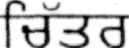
ਚਿੱਤਰ
